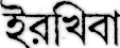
ইরখিবা
